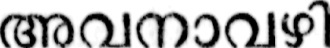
അവനാവഴി
